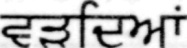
ਵੜਦਿਆਂ
